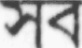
সব
